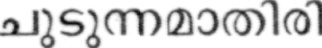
ചുടുന്നമാതിരി
